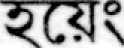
হয়েং
